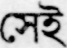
সেই
